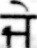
ਜੇ
